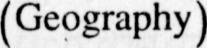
(Geography)
